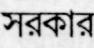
সরকার
